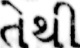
તેથી
